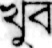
খুব
